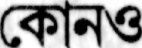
কোনও
